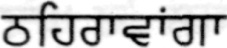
ਠਹਿਰਾਵਾਂਗਾ
